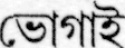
ভোগাই
